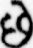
છે
